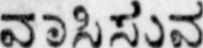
ವಾಸಿಸುವ
